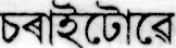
চৰাইটোৱে
